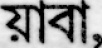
য়াবা,
